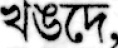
খঙদে,
